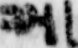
આ
